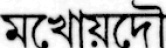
মখোয়দৌ
